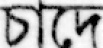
চাদে
